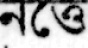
নত্তে
